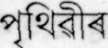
পৃথিৱীৰ
